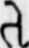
તે
